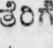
ತೆರಿಗೆ
